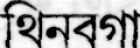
থিনবগা
